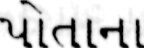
'પોતાના
